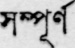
সম্পূর্ণ
